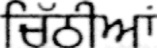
ਚਿੱਠੀਆਂ
